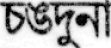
চঙদুনা
